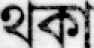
থকা
